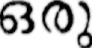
ഒരു
